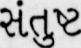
સંતુષ્ટ
